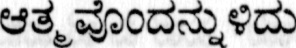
ಆತ್ಮವೊಂದನ್ನುಳಿದು
